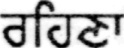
ਰਹਿਣਾ
